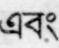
এবং
